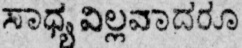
ಸಾಧ್ಯವಿಲ್ಲವಾದರೂ
